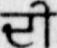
ਦੀ
